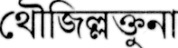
থৌজিল্লক্তুনা
